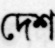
দেশ
